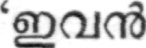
‘ഇവന്‍
